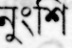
নুংশি
